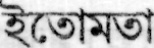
ইতোমতা
